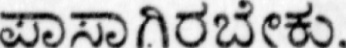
ಪಾಸಾಗಿರಬೇಕು.
